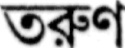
তরুণ
